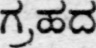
ಗ್ರಹದ
